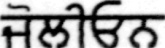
ਜੋਲੀਓਨ
